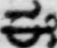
ಈ
